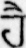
ਹੈ
